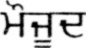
ਮੌਜੂਦ
